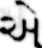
એ
